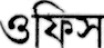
ওফিস
